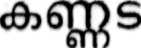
കണ്ണട
